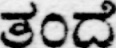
ತಂದೆ
